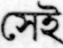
সেই
